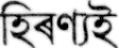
হিৰণ্যই
